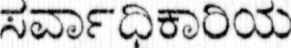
ಸರ್ವಾಧಿಕಾರಿಯ
